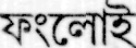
ফংলোই
